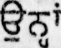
ਉਨ੍ਹਾਂ
